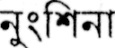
নুংশিনা
